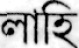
লাহি
